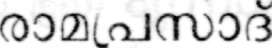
രാമപ്രസാദ്
